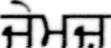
ਜੇਮਜ਼
